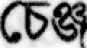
চেঞ্জ
